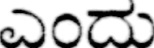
ಎಂದು
